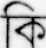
কি
